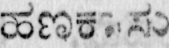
ಹಣಕಾಸು
